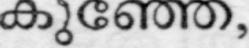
കുഞ്ഞേ,
